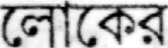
লোকের
